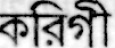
করিগী
